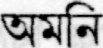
অমনি
